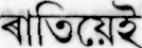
ৰাতিয়েই
